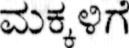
ಮಕ್ಕಳಿಗೆ
